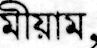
মীয়াম,
